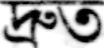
দ্রুত
